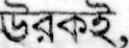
উরকই,
